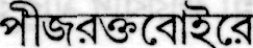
পীজরক্তবোইরে
